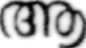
ആ
